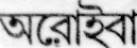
অরোইবা
